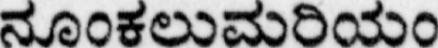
ನೂಂಕಲುಮರಿಯಂ
